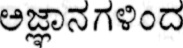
ಅಜ್ಞಾನಗಳಿಂದ
